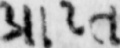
પ્રાપ્ત
